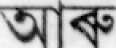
আৰু
